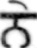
ਨੇ
